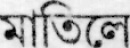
মাতিলে
